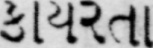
કાયરતા
